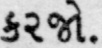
કરજો.
